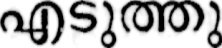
എടുത്തു
